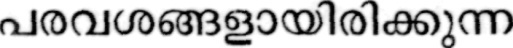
പരവശങ്ങളായിരിക്കുന്ന
